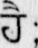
ਹੈ;
